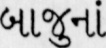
બાજુનાં
